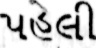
પહેલી
